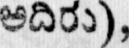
ಅದಿರು),
